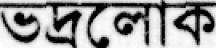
ভদ্রলোক
